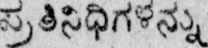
ಪ್ರತಿನಿಧಿಗಳನ್ನು
